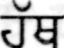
ਹੱਥ
